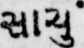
સાચું
